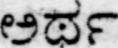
ಅರ್ಥ
